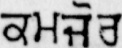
ਕਮਜੋਰ
